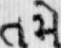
તમે
